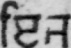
ਇਸ
